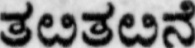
ತೞತೞನೆ
